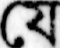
যে
